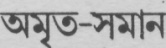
অমৃত-সমান
